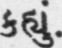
કહ્યું.
